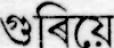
গুৰিয়ে
